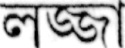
লজ্জা
